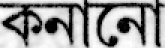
কনানো
